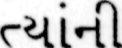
ત્યાંની
